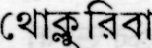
থোক্লুরিবা
